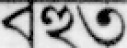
বহুত
